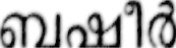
ബഷീര്‍
